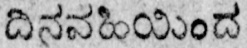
ದಿನವಹಿಯಿಂದ
